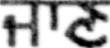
ਜਾਣ
